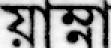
য়াম্না
